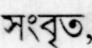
সংবৃত,
